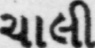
ચાલી
